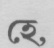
হে,
